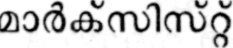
മാര്‍ക്സിസ്റ്റ്
